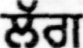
ਲੱਗ
